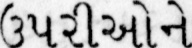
ઉપરીઓને
